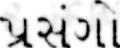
પ્રસંગો
